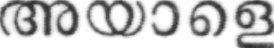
അയാളെ
